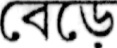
বেড়ে
